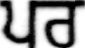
ਪਰ
